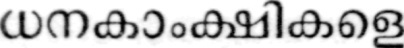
ധനകാംക്ഷികളെ
